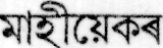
মাহীয়েকৰ
